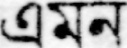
এমন
